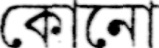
কোনো
